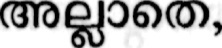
അല്ലാതെ,
